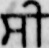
ਸੀ
